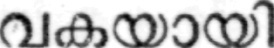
വകയായി
